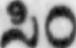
ಸಿಂ
